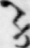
કે
